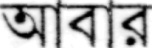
আবার
